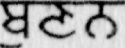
ਬੁਣਨ
